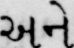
અને
